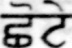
ਛੋਟੇ
